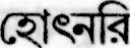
হোৎনরি
